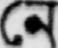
নে
